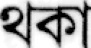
থকা
